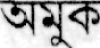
অমুক
